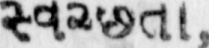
સ્વચ્છતા,
